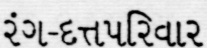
રંગ-દત્તપરિવાર
